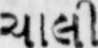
ચાલી
